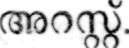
അറസ്റ്റ്.
